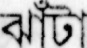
ঝাঁটা
